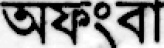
অফংবা
